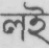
লই
